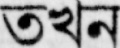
তখন
